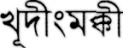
খূদীংমক্কী
